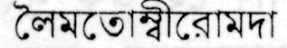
লৈমতোম্বীরোমদা
